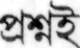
প্রশ্নই
